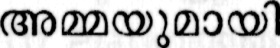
അമ്മയുമായി
